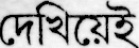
দেখিয়েই
